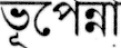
ভূপেন্না
